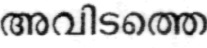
അവിടത്തെ
